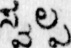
ಸ್ವಲ್ಪ
